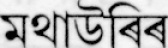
মথাউৰিৰ
